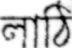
লাঠি
